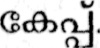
കേപ്പ്.
